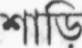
শাড়ি
